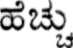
ಹೆಚ್ಚು
